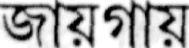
জায়গায়
